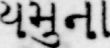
યમુના
